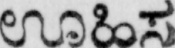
ಊಹಿಸ
